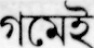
গমেই
